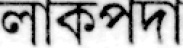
লাকপদা
